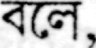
বলে,
